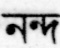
নন্দ
